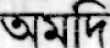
অমদি
